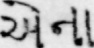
એના
